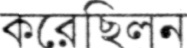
করেছিলেন
